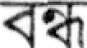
বন্ধ
